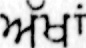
ਅੱਖਾਂ
